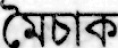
মৈচাক
